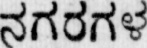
ನಗರಗಳ
